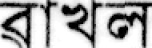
ৱাখল
